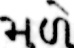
મળે
